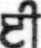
ਈ
